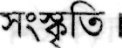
সংস্কৃতি।
